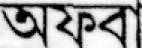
অফবা
